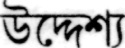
উদ্দেশ্য
